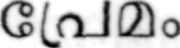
പ്രേമം
